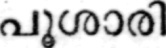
പൂശാരി
